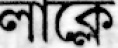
লাক্লে
